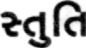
સ્તુતિ
